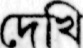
দেখি
